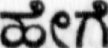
ಹೇಗೆ
